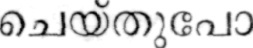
ചെയ്തുപോ
